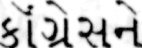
કૉંગ્રેસને
